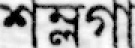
শম্লগা
